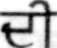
ਦੀ
